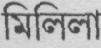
মিলিলা
